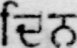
ਦਿਨ
